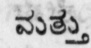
ಮತ್ತು
